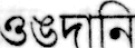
ওঙদানি
